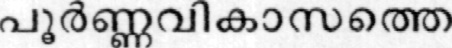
പൂര്‍ണ്ണവികാസത്തെ
